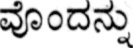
ವೊಂದನ್ನು
